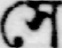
সে
